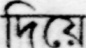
দিয়ে
